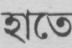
হাতে
